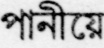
পানীয়ে
